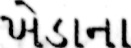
ખેડાના
